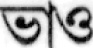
ভাও
